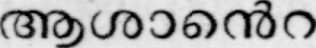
ആശാന്റെ
